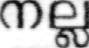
നല്ല
